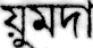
য়ুমদা
